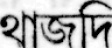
থাজদি
